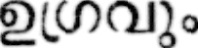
ഉഗ്രവും
